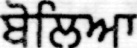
ਬੋਲਿਆ
